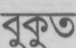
বুকুত
